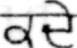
ਕਦੇ
